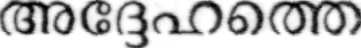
അദ്ദേഹത്തെ
